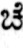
ಚೆ
